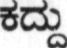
ಕದ್ದು
